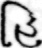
હિ
